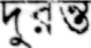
দুরন্ত
